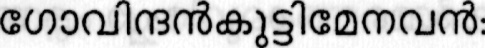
ഗോവിന്ദന്‍കുട്ടിമേനവന്‍:
